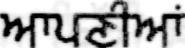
ਆਪਣੀਆਂ
